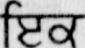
ਇਕ
